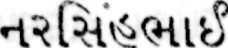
નરસિંહભાઈ
